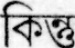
কিন্তু
